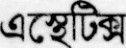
এস্থেটিক্স
